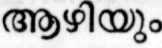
ആഴിയും
